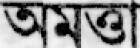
অমত্তা
